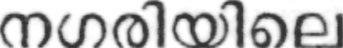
നഗരിയിലെ
